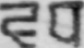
ਵਧ
